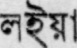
লইয়া
